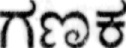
ಗಣಕ
